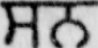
ਸਨ
